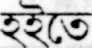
হইতে
